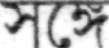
সঙ্গে
